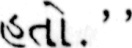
હતો."
